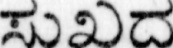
ಸುಖದ
